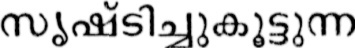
സൃഷ്ടിച്ചുകൂട്ടുന്ന
